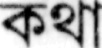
কথা
